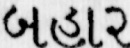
બહાર
